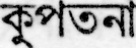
কুপতনা
